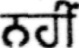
ਨਹੀਂ
